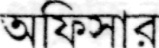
অফিসার
